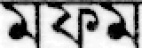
মফম
